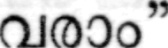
വരാം”
